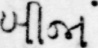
બીજાં
